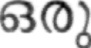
ഒരു
